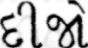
દીજો
